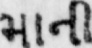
માની
